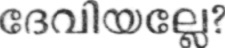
ദേവിയല്ലേ?
